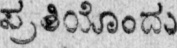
ಪ್ರತಿಯೊಂದು
